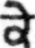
ਕੇ
